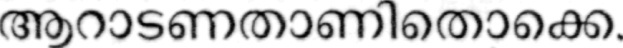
ആറാടണതാണിതൊക്കെ.
